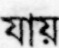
যায়
